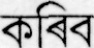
কৰিব
